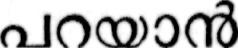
പറയാന്‍
